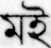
মই
